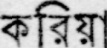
করিয়া
